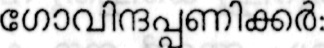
ഗോവിന്ദപ്പണിക്കര്‍:
